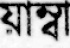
য়াম্বা
